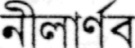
নীলার্ণব
